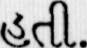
હતી.
